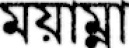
ময়াম্না
